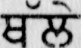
ਥੱਲੇ
